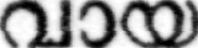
വായ
